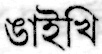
ঙাইখি
